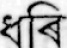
ধৰি
